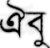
ঐবু
